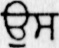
ਉਸ
